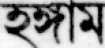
হঙ্গাম
